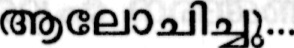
ആലോചിച്ചു...
